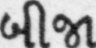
બીજા
